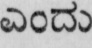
ಎಂದು
